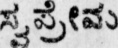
ಸ್ವಪ್ರೇಮ
